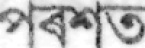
পৰশত
